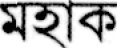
মহাক
